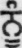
ਨੂੰ
